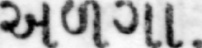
અળગા.
